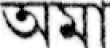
অমা
